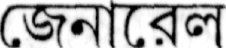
জেনারেল
